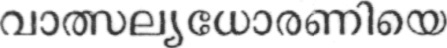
വാത്സല്യധോരണിയെ
